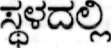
ಸ್ಥಳದಲ್ಲಿ
